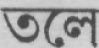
তলে
